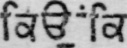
ਕਿਉਂਕਿ
